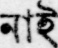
নাই
